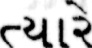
ત્યારે
